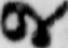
જ
